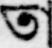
তা
